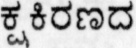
ಕ್ಷಕಿರಣದ
